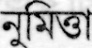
নুমিত্তা
